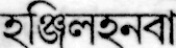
হঞ্জিনহনবা
